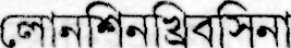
লোনশিনখ্রিবসিনা
